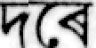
দৰে
